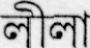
লীলা
